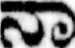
ನಾ
